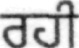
ਰਹੀ
